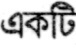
একটি
